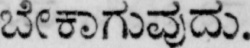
ಬೇಕಾಗುವುದು.
